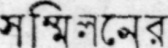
সম্মিলনের
